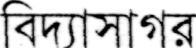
বিদ্যাসাগর
